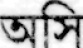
অসি
